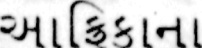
આફ્રિકાના
